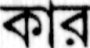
কার
